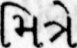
મિત્રે
